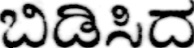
ಬಿಡಿಸಿದ
